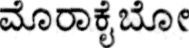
ಮೊರಾಕೈಬೋ
